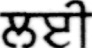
ਲਈ
